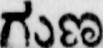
ಗುಣ
